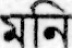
মনি
